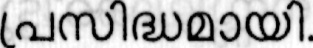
പ്രസിദ്ധമായി.
